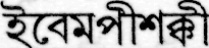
ইবেমপীশক্কী
